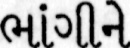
ભાંગીને
